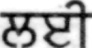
ਲਈ
